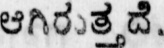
ಆಗಿರುತ್ತದೆ.
